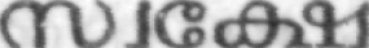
സ്വക്ഷേ
